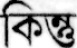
কিন্তু
